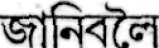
জানিবলৈ
